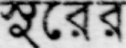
সুরের
